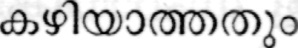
കഴിയാത്തതും
